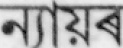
ন্যায়ৰ
